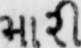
મારી
